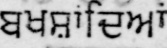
ਬਖਸ਼ਾਦਿਆਂ
